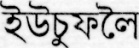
ইউচুফলৈ
